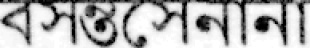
বসন্তসেনানা
